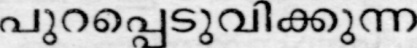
പുറപ്പെടുവിക്കുന്ന
